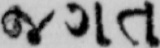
જગત
